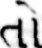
તો
